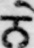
ਨੇ
